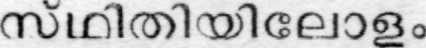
സ്ഥിതിയിലോളം
